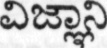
ವಿಜ್ಞಾನಿ
